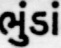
ભુંડાં
